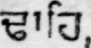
ਢਾਹਿ,
